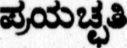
ಪ್ರಯಚ್ಛತಿ
